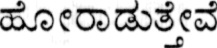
ಹೋರಾಡುತ್ತೇವೆ
